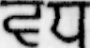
ਵਧ
